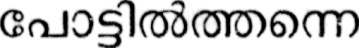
പോട്ടില്‍ത്തന്നെ
